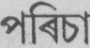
পৰিচা
